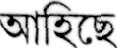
আহিছে
